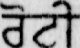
ਰੋਟੀ
